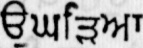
ਉਘੜਿਆ
